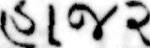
હાજર
